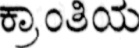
ಕ್ರಾಂತಿಯ
